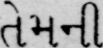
તેમની
